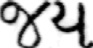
જય
